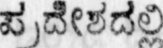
ಪ್ರದೇಶದಲ್ಲಿ
